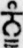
ਨੂੰ
